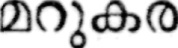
മറുകര
